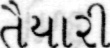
તૈયારી
